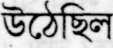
উঠেছিল
